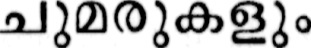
ചുമരുകളും
